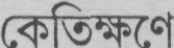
কেতিক্ষণে
